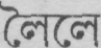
লৈলে
